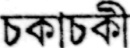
চকাচকী
